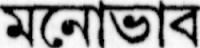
মনোভাব
